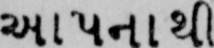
આપનાથી
